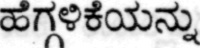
ಹೆಗ್ಗಳಿಕೆಯನ್ನು
